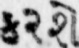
કરશે
